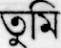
তুমি
